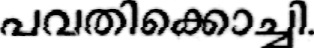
പവതിക്കൊച്ചി.
